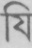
যি
